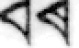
বৰ
